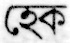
হেক
